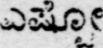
ಎಷ್ಟೋ
